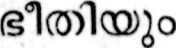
ഭീതിയും
